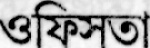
ওফিসতা
